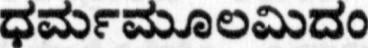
ಧರ್ಮಮೂಲಮಿದಂ
